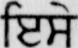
ਇਸੇ
